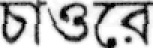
চাওরে
